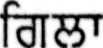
ਗਿਲਾ
